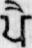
ਪੈ
